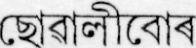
ছোৱালীবোৰ
